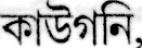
কাউগনি,
